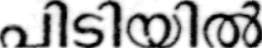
പിടിയില്‍
